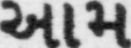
આમ
